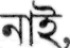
নাই,
